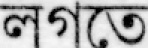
লগতে
